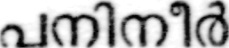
പനിനീര്‍
